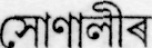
সোণালীৰ
